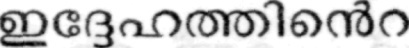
ഇദ്ദേഹത്തിന്റെ
